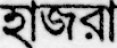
হাজরা
